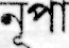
নূপা
